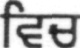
ਵਿਚ
